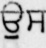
ਉਸ
